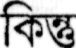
কিন্তু
